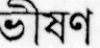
ভীষণ
